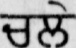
ਚਲੇ
